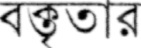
বক্তৃতার
